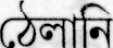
ঠেলানি
